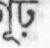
গূঢ়
